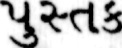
પુસ્તક
